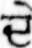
ਦੇ
